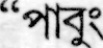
“পাবুং
